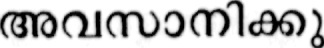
അവസാനിക്കു
